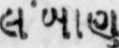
લંબાણ
